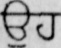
ਉਹ
